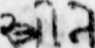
સ્ત્રીને
